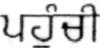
ਪਹੁੰਚੀ
